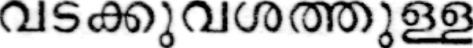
വടക്കുവശത്തുള്ള
